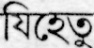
যিহেতু
